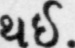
થઈ.
